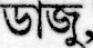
ডাজু,
